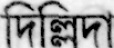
দিল্লিদা
